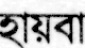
হায়বা
